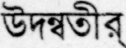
উদন্বতীর্
